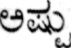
ಅಷ್ಟು
